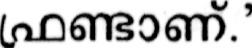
ഫ്രണ്ടാണ്.’
